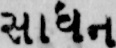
સાધન
